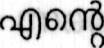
എന്റെ
